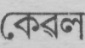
কেৱল
